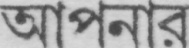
আপনার
